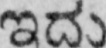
ಇದು
